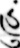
હું
